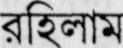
রহিলাম
